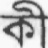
কী
